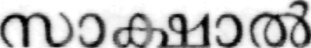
സാക്ഷാല്‍
